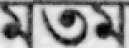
মতম
